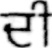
ਦੀ
